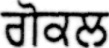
ਗੋਕਲ
